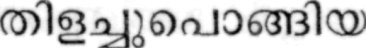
തിളച്ചുപൊങ്ങിയ
